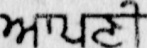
ਆਪਣੀ
